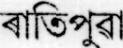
ৰাতিপুৱা
